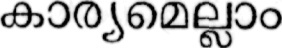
കാര്യമെല്ലാം
